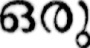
ഒരു
